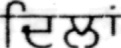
ਦਿਲਾਂ
